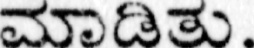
ಮಾಡಿತು.
